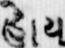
હોય
